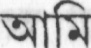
আমি
